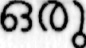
ഒരു
